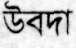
উবদা
